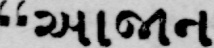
“આજાન
